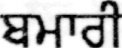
ਬਮਾਰੀ
